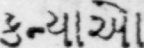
કન્યાઓ
